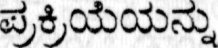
ಪ್ರಕ್ರಿಯೆಯನ್ನು
